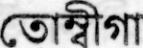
অতোম্বীগা
